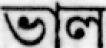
ভাল
